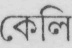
কেলি
